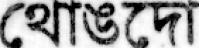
থোঙদো
